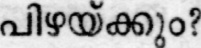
പിഴയ്ക്കും?
